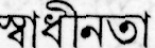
স্বাধীনতা
